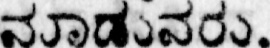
ಮಾಡುವರು.
